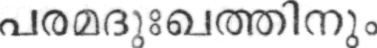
പരമദുഃഖത്തിനും
